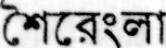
শৈরেংলা
